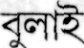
বুলাই
